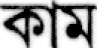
কাম
